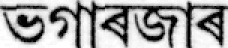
ভগাৰজাৰ
